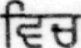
ਵਿਚ
